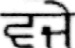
ਵਜੇ
